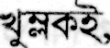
খুম্লকই,
